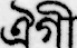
ঐগী
